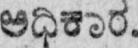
ಅಧಿಕಾರ.
